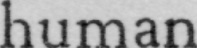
human
